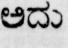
ಅದು
